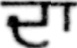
ਦਾ
